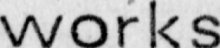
works
